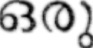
ഒരു
